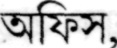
অফিস,
